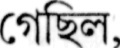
গেছিল,
